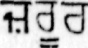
ਜ਼ਰੂਰ
